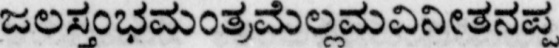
ಜಲಸ್ತಂಭಮಂತ್ರಮೆಲ್ಲಮವಿನೀತನಪ್ಪ
